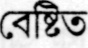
বেষ্টিত
